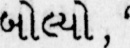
બોલ્યો,'
